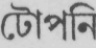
টোপনি
